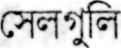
সেলগুলি
